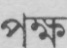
পক্ষ
